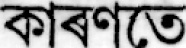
কাৰণতে
